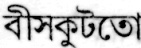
বীসকুটতো
